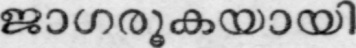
ജാഗരൂകയായി
